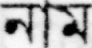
নাম
